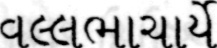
વલ્લભાચાર્યે
